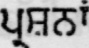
ਪ੍ਰਸ਼ਨਾਂ
